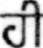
ਹੀ
